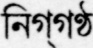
নিগ্গণ্ঠ
